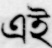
এই
